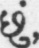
છું,
